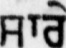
ਸਾਰੇ
